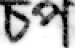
চপ
